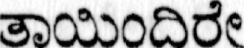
ತಾಯಿಂದಿರೇ
